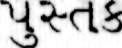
પુસ્તક
